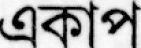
একাপ
